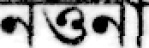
নত্তনা
